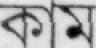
কাম
